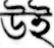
উই
